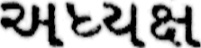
અધ્યક્ષ
